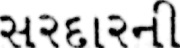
સરદારની
